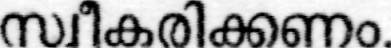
സ്വീകരിക്കണം.
